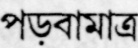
পড়বামাত্র
